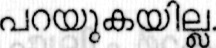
പറയുകയില്ല.
